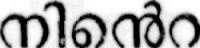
നിന്റെ
